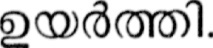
ഉയര്‍ത്തി.
